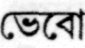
ভেবো
